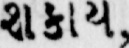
શકાય,
